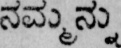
ನಮ್ಮನ್ನು
